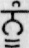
ਨੂੰ
